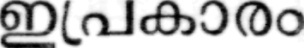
ഇപ്രകാരം
